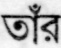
তাঁর
